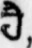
ਹੈ,
